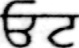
ਓਟ
